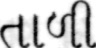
તાળી
